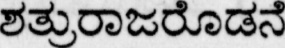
ಶತ್ರುರಾಜರೊಡನೆ
